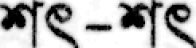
শৎ-শৎ
